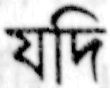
যদি
